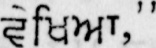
ਵੇਖਿਆ,''
